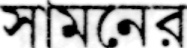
সামনের
